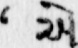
'એ
